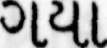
ગયા
